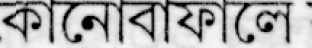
কোনোবাফালে
